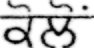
ਕੋਲੋਂ
